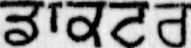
ਡਾਕਟਰ
